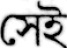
সেই
